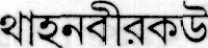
থাহনবীরকউ
